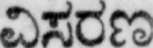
ವಿಸರಣ
